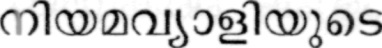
നിയമവ്യാളിയുടെ
